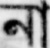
না
